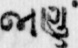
જાણું
